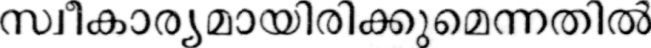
സ്വീകാര്യമായിരിക്കുമെന്നതില്‍
